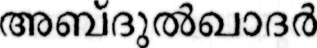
അബ്ദുല്‍ഖാദര്‍
